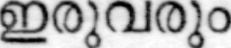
ഇരുവരും
